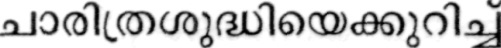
ചാരിത്രശുദ്ധിയെക്കുറിച്ച്
